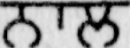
ਨਾਲ
